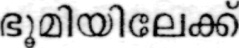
ഭൂമിയിലേക്ക്
